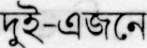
দুই-এজনে
